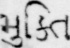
મુક્તિ
